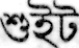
শুইট
